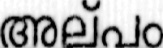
അല്പം
